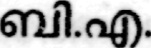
ബി.എ.
